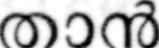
താന്‍
